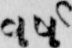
વર્ષ
